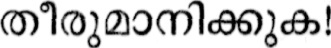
തീരുമാനിക്കുക!
